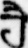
ਹੈ
